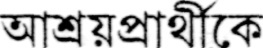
আশ্রয়প্রার্থীকে
